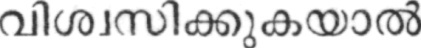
വിശ്വസിക്കുകയാല്‍
